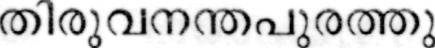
തിരുവനന്തപുരത്തു
